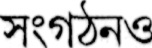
সংগঠনও
